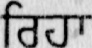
ਰਿਹਾ
